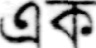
এক
